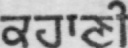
ਕਹਾਣੀ
